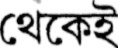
থেকেই
